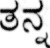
ತನ್ನ
